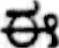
ಈ
